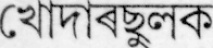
খোদাৰছুলক
